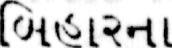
બિહારના
